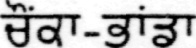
ਚੌਂਕਾ-ਭਾਂਡਾ
